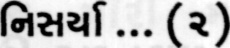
નિસર્યા........(૨)
